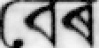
বেৰ
